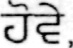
ਹੋਵੇ,
